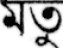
মতু
